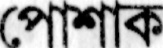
পোশাক
